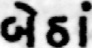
બેઠાં
